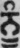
ਨੂੰ
